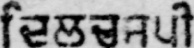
ਦਿਲਚਸਪੀ
